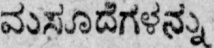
ಮಸೂದೆಗಳನ್ನು
